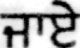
ਜਾਏ
